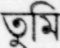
তুমি
